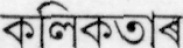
কলিকতাৰ
